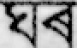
ঘৰ
